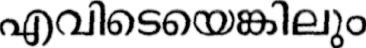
എവിടെയെങ്കിലും
